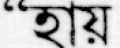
“হায়
